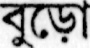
বুড়ো
